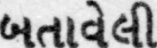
બતાવેલી
